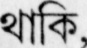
থাকি,
